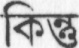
কিন্তু
